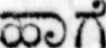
ಹಾಗೆ
